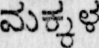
ಮಕ್ಕಳ
